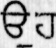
ਉਹ
